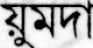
য়ুমদা
